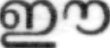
ഈ
